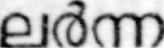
ലര്‍ന്ന
